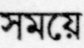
সময়ে
